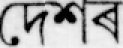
দেশৰ
